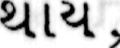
થાય,
